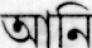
আনি
